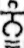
ਨੂੰ
